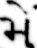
મેં
